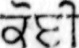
ਕੋਈ
